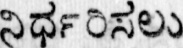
ನಿರ್ಧರಿಸಲು
